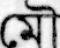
মৌ
